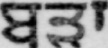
ਬੜਾ
